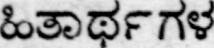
ಹಿತಾರ್ಥಗಳ
